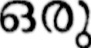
ഒരു
